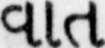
વાત
